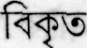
বিকৃত
